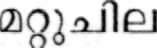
മറ്റുചില
